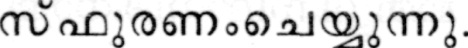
സ്ഫുരണംചെയ്യുന്നു.
